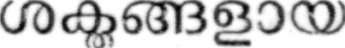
ശക്തങ്ങളായ
